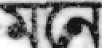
মনে
